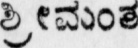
ಶ್ರೀಮಂತ
